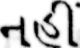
નહીં
